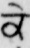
ਕੇ
